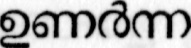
ഉണര്‍ന്ന
